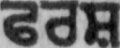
ਫਰਸ਼
